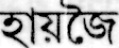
হায়জৈ
